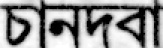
চানদবা
